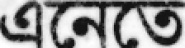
এনেতে
